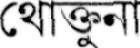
থোক্তুনা
